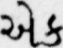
એક
